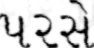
પરસે
